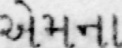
એમના
